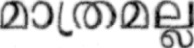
മാത്രമല്ല
